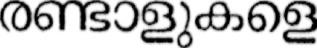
രണ്ടാളുകളെ
